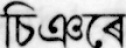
চিঞৰে
